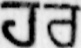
ਹਰ
